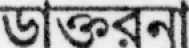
ডাক্তরনা
